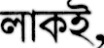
লাকই,
